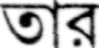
তার
